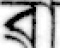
ৱা
